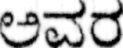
ಅವರ
